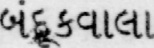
બંદૂકવાલા
